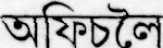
অফিচলৈ
